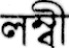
লম্বী
